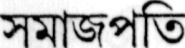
সমাজপতি
